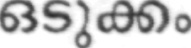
ഒടുക്കം
